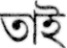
তাই
